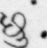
છું.
